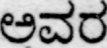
ಅವರ
